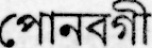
পোনবগী
